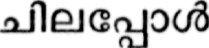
ചിലപ്പോള്‍
